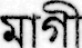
মাগী
